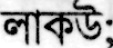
লাকউ;
